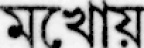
মখোয়
